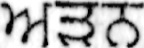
ਅੜਨ
